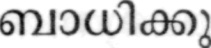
ബാധിക്കു
